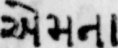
એમના
